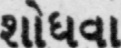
શોધવા
